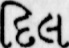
દિલ
